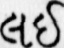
લઈ
